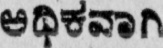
ಅಧಿಕವಾಗಿ
